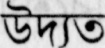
উদ্যত
